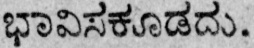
ಭಾವಿಸಕೂಡದು.
